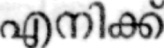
എനിക്ക്
